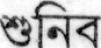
শুনিব
